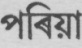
পৰিয়া
